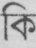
কি
